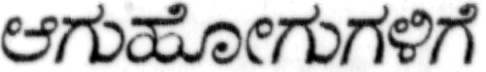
ಆಗುಹೋಗುಗಳಿಗೆ
